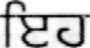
ਇਹ
